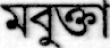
মবুক্তা
